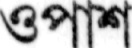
ওপাশ
